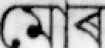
মোৰ
